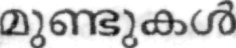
മുണ്ടുകള്‍
